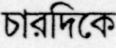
চারদিকে
